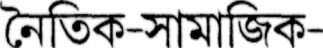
নৈতিক-সামাজিক-
